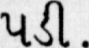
પડી.
